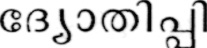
ദ്യോതിപ്പി
